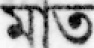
মাত
